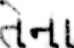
તેના
